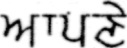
ਆਪਣੇ
